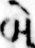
બે
